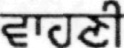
ਵਾਹਣੀ
